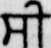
ਸੀ
